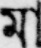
মা
